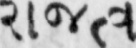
રાજત્વ
